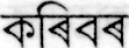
কৰিবৰ
